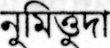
নুমিত্তুদা
